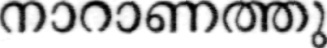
നാറാണത്തു
